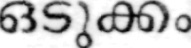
ഒടുക്കം
